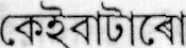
কেইবাটাৰো
